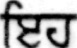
ਇਹ
